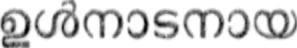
ഉള്‍നാടനായ
